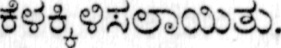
ಕೆಳಕ್ಕಿಳಿಸಲಾಯಿತು.
